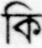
কি
